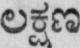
ಲಕ್ಷಣ
